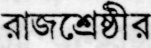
রাজশ্রেষ্ঠীর
